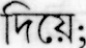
দিয়ে;
